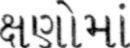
ક્ષણોમાં
